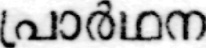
പ്രാര്‍ഥന
